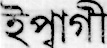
ইপ্বাগী
